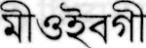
মীওইবগী
